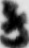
કરે
